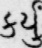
કર્યું
